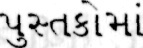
પુસ્તકોમાં
